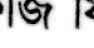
ফিজি
